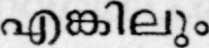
എങ്കിലും
